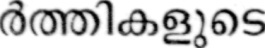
ര്‍ത്തികളുടെ
